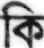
কি
